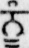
ਨੂੰ
